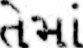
તેમાં
